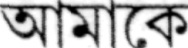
আমাকে
